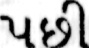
પછી
